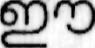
ഈ
